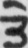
ਤੇ
